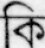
কি
